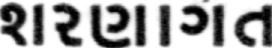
શરણાગત
